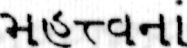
મહત્ત્વનાં
